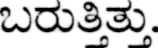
ಬರುತ್ತಿತ್ತು.
